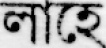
লাহে
